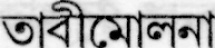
তাবীমোলনা
